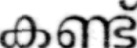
കണ്ട്
